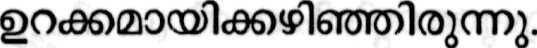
ഉറക്കമായിക്കഴിഞ്ഞിരുന്നു.
